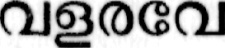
വളരവേ
